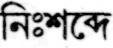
নিঃশব্দে
